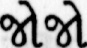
જોજો
